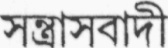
সন্ত্রাসবাদী
